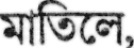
মাতিলে,
